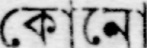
কোনো
